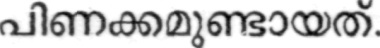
പിണക്കമുണ്ടായത്.
